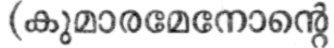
(കുമാരമേനോന്റെ
